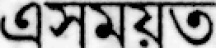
এসময়ত
